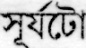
সূর্যটো
